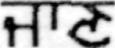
ਜਾਣ
